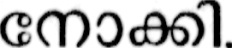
നോക്കി.
